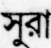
সুরা
